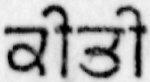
ਕੀਤੀ
